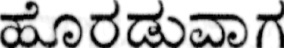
ಹೊರಡುವಾಗ
